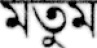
মতুম
